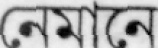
নেমানে
